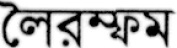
লৈরম্ফম
